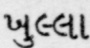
ખુલ્લા
